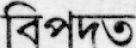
বিপদত
